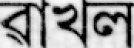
ৱাখল
